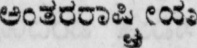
ಅಂತರರಾಷ್ಟ್ರೀಯ
